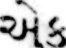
એક
